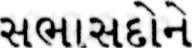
સભાસદોને
